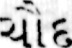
ચૌદ
